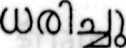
ധരിച്ചു
